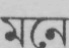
মনে
